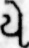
યે
